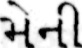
મેની
